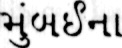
મુંબઈના
